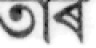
তাৰ
